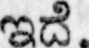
ಇದೆ.
